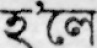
হ'লে
